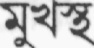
মুখস্থ
